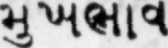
મુખભાવ
